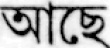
আছে
